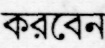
করবেন
